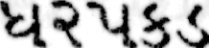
ધરપકડ
